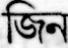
জিন
